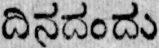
ದಿನದಂದು
